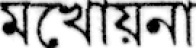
মখোয়না
